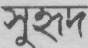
সুহৃদ
